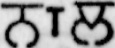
ਨਾਲ
